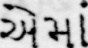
એમાં
